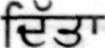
ਦਿੱਤਾ
